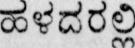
ಹಳದರಲ್ಲಿ
